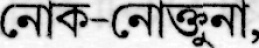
নোক-নোক্তুনা,
